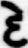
દે
